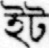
ইট
